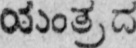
ಯಂತ್ರದ
